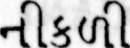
નીકળી
